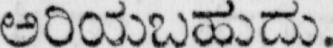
ಅರಿಯಬಹುದು.
